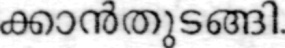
ക്കാന്‍തുടങ്ങി.
